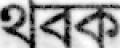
থবক
